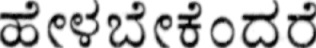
ಹೇಳಬೇಕೆಂದರೆ
